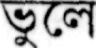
ভুলে
